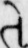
તે
